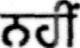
ਨਹੀਂ
